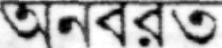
অনবরত
